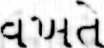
વખતે
